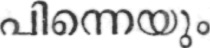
പിന്നെയും
